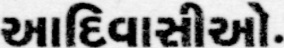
આદિવાસીઓ.
